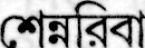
শেন্নরিবা
